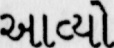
આવ્યો
